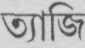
ত্যাজি
